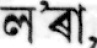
ল'ৰা,
